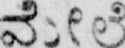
ಮೇಲೆ
